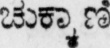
ಚುಕ್ಕಾಣಿ
